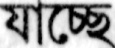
যাচ্ছে
